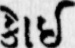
કોઈ
